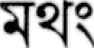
মথং
